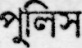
পুলিস
